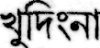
খুদিংনা
